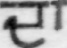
ਦਾ
